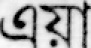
এয়া
